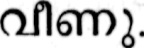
വീണു.
